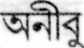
অনীবু
